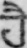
ਹੈ
